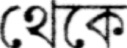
থেকে
